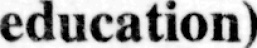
education)
